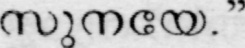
സുനയേ."
